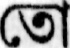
তো
